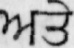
ਅਤੇ
